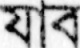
যাব
